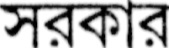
সরকার
